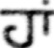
ਹਾਂ
